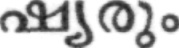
ഷ്യരും
